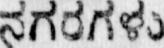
ನಗರಗಳು
